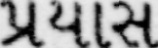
પ્રયાસ
